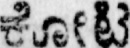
ಕೋಟಿ
